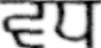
ਵਧ
